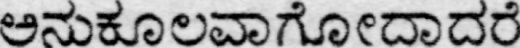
ಅನುಕೂಲವಾಗೋದಾದರೆ
